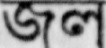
জল
